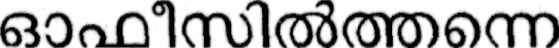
ഓഫീസില്‍ത്തന്നെ
